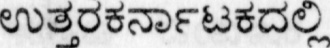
ಉತ್ತರಕರ್ನಾಟಕದಲ್ಲಿ
